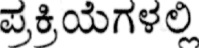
ಪ್ರಕ್ರಿಯೆಗಳಲ್ಲಿ
